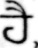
ਹੈ,
